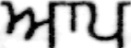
ਆਪ
